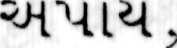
અપાય,
